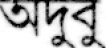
অদুবু
